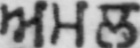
ਅਮਲ
